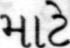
માટે
